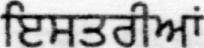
ਇਸਤਰੀਆਂ
